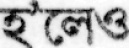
হ'লেও
